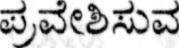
ಪ್ರವೇಶಿಸುವ
